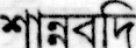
শান্নবদি
